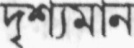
দৃশ্যমান
